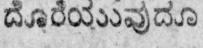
ದೊರೆಯುವುದೂ
